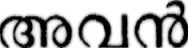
അവന്‍
